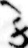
કે
